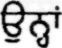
ਉਨ੍ਹਾਂ
